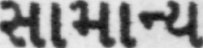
સામાન્ય
